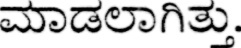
ಮಾಡಲಾಗಿತ್ತು.
